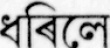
ধৰিলে
